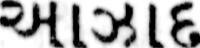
આઝાદ
